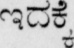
ಇದಕ್ಕೆ
